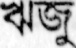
ঋজু
